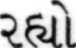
રહ્યો
